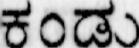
ಕಂಡು
